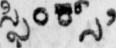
ಸ್ಫಿಂಕ್ಸ್’
